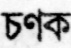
চণক
